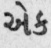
એક
